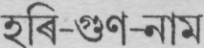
হৰি-গুণ-নাম
